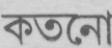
কতনো
